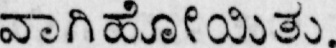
ವಾಗಿಹೋಯಿತು.
